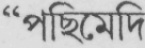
"পছিমেদি
